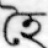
হৈ
